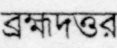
ব্রহ্মদত্তর
